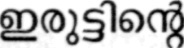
ഇരുട്ടിന്റെ
